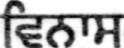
ਵਿਨਾਸ
